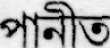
পানীত
